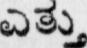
ಎತ್ತು
